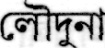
লৌদুনা
